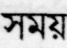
সময়
